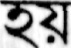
হয়
